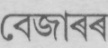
বেজাৰৰ
